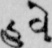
હવે
